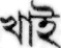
খাই
